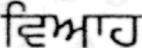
ਵਿਆਹ
